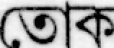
তোক
